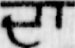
ਦਾ
